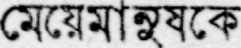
মেয়েমানুষকে
